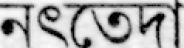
নৎতেদা
